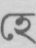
হে
